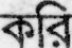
করি
